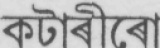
কটাৰীৰো
